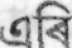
এৰি
